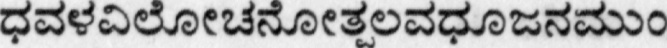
ಧವಳವಿಲೋಚನೋತ್ಪಲವಧೂಜನಮುಂ
